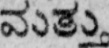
ಮತ್ತು
